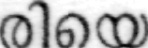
രിയെ
